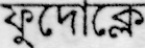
ফুদোক্লে
